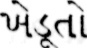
ખેડૂતો
